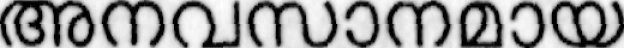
അനവസാനമായ
